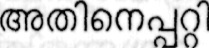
അതിനെപ്പറ്റി
